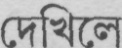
দেখিলে
